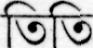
তিতি
